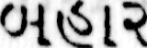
બહાર
